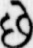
છે
